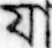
যা
